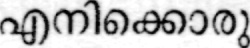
എനിക്കൊരു
